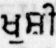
ਖੁਸ਼ੀ
